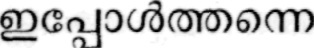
ഇപ്പോള്‍ത്തന്നെ
